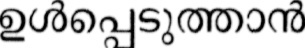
ഉള്‍പ്പെടുത്താന്‍
